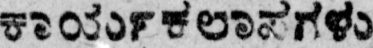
ಕಾರ್ಯಕಲಾಪಗಳುತ
